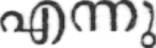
എന്നു
